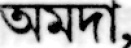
অমদা,
